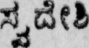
ಸ್ವದೇಶಿ
